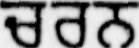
ਚਰਨ
